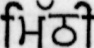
ਮਿੱਠੀ
